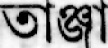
তাঞ্জা
